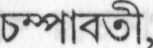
চম্পাবতী,
